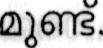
മുണ്ട്.
